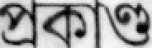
প্রকাণ্ড
